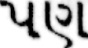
પણ
